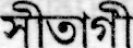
সীতাগী
